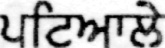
ਪਟਿਆਲੇ
